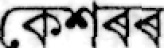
কেশৰৰ
